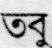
তবু
